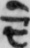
ਦੇ
